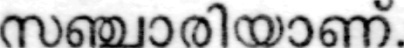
സഞ്ചാരിയാണ്.
